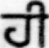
ਹੀ
